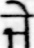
ਜੇ
